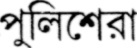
পুলিশেরা
